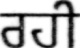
ਰਹੀ
